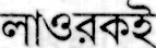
লাওরকই
